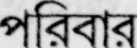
পরিবার
